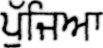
ਪੁੱਜਿਆ
